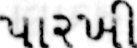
પારખી
